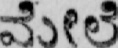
ಮೇಲೆ
